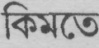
কিমতে
